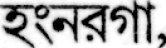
হংনরগা,
